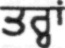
ਤਰ੍ਹਾਂ
